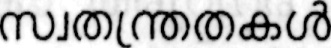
സ്വതന്ത്രതകള്‍
